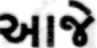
આજે
